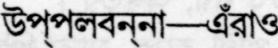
উপ্পলবন্না-এঁরাও
